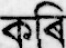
কৰি
